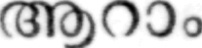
ആറാം
